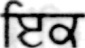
ਇਕ
